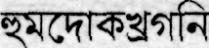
হুমদোকখ্রগনি
